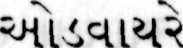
ઓડવાયરે
